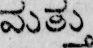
ಮತ್ತು
